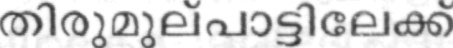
തിരുമുല്പാട്ടിലേക്ക്
